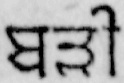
ਬੜੀ
